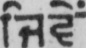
ਜਿਵੇਂ
